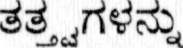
ತತ್ತ್ವಗಳನ್ನು
